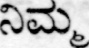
ನಿಮ್ಮ
